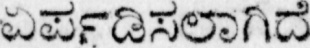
ಏರ್ಪಡಿಸಲಾಗಿದೆ
